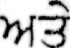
ਅਤੇ
